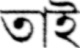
তাই
